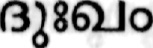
ദുഃഖം
